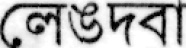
লেঙদবা
